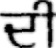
ਦੀ
